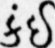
કંઈ
